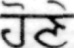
ਹੋਣੇ
